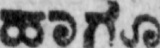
ಹಾಗೂ
